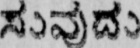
ಸುವುದು
